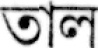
তাল
